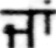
ਜਾਂ
